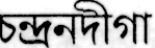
চন্দ্রনদীগা
